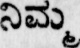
ನಿಮ್ಮ
